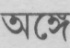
অঙ্গে
